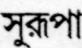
সুরূপা
